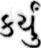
કર્યું
